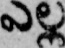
ಎಲ್ಲ
